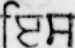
ਇਸ
